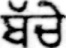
ਬੱਚੇ
